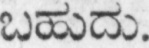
ಬಹುದು.
